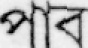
পাব
